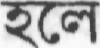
হলে
